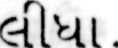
લીધા.
